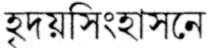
হৃদয়সিংহাসনে
